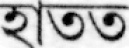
হাতত
